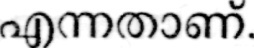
എന്നതാണ്.
